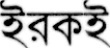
ইরকই
